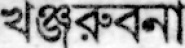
খঞ্জরুবনা
